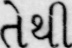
તેથી
